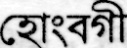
হোংবগী
